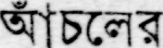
আঁচলের
